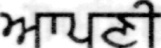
ਆਪਣੀ
